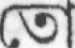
তো
